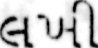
લખી
